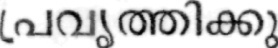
പ്രവൃത്തിക്കു
